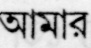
আমার
